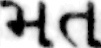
મત
